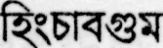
হিংচাবগুম
